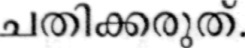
ചതിക്കരുത്.
